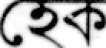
হেক
